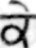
ਕੇ
